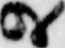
જ
